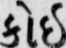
કોઈ
